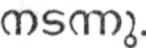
നടന്നു.
